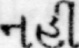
નહીં
